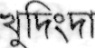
খুদিংদা
